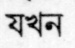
যখন
